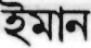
ইমান
